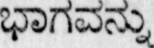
ಭಾಗವನ್ನು
